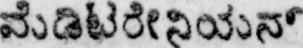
ಮೆಡಿಟರೇನಿಯನ್
